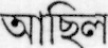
আছিল
